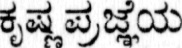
ಕೃಷ್ಣಪ್ರಜ್ಞೆಯ
